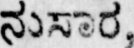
ನುಸಾರ,
